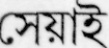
সেয়াই
